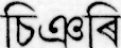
চিঞৰি
